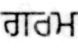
ਗਰਮ
